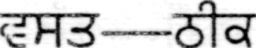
ਵਸਤ-ਠੀਕ
